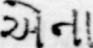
એના
